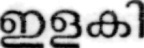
ഇളകി
